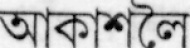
আকাশলৈ
